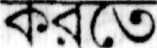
করতে
